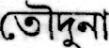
তৌদুনা
